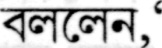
বললেন,
